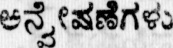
ಅನ್ವೇಷಣೆಗಳು
